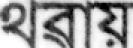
থৱায়
